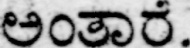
ಅಂತಾರೆ.
